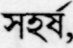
সহর্ষ,
